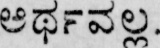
ಅರ್ಥವಲ್ಲ.
